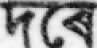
দৰে
